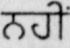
ਨਹੀਂ
